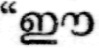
“ഈ
